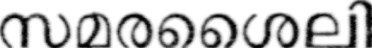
സമരശൈലി
